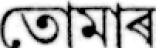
তোমাৰ
